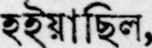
হইয়াছিল,
